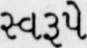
સ્વરૂપે
